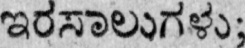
ಇರಸಾಲುಗಳು;
